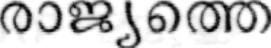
രാജ്യത്തെ
